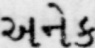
અનેક
